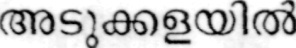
അടുക്കളയില്‍
